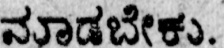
ಮಾಡಬೇಕು.
